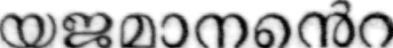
യജമാനന്റെ
